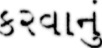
કરવાનું
